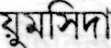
য়ুমসিদা
